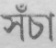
সঁচা
